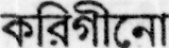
করিগীনো
